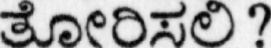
ತೋರಿಸಲಿ?
